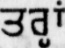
ਤਰ੍ਹਾਂ
